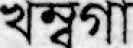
খম্বগা
